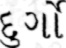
દુર્ગો
